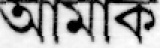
আমাক
